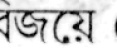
বিজয়ে
